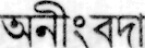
অনীংবদা
